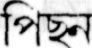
পিছন
